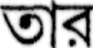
তার
